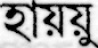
হায়য়ু
